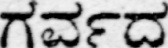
ಗರ್ವದ
